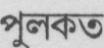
পুলকত
